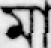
মা
